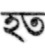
হত
